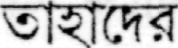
তাহাদের
